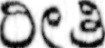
ರೀತಿ
